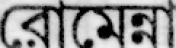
রোমেন্না
